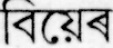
বিয়েৰ
